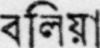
বলিয়া
